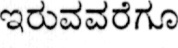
ಇರುವವರೆಗೂ
